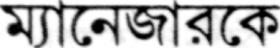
ম্যানেজারকে
